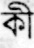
কী
